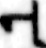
ન
